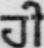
ਹੀ
